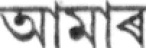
আমাৰ
